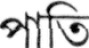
পাতি
